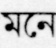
মনে
